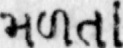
મળતાં
